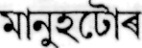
মানুহটোৰ
